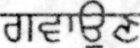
ਗਵਾਉਣ
